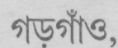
গড়গাঁও,
